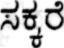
ಸಕ್ಕರೆ
